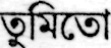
তুমিতো
